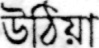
উঠিয়া
